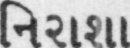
નિરાશા
